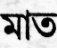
মাত
